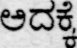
ಅದಕ್ಕೆ
